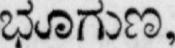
ಭೂಗುಣ,
